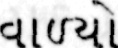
વાળ્યો
